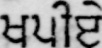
ਖਪੀਏ
